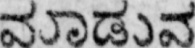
ಮಾಡುವ
